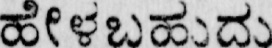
ಹೇಳಬಹುದು
